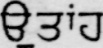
ਉਤਾਂਹ
